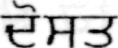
ਦੋਸਤ
